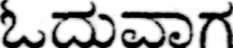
ಓದುವಾಗ
